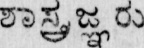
ಶಾಸ್ತ್ರಜ್ಞರು
